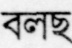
বলছ
